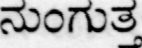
ನುಂಗುತ್ತ
